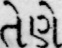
તેણે
